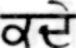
ਕਦੇ
